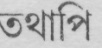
তথাপি
